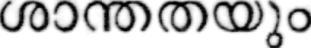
ശാന്തതയും
